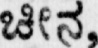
ಚೀನ,
